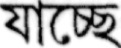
যাচ্ছে
